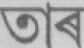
তাৰ
